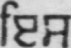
ਇਸ
